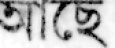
আছে
